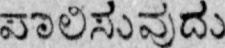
ಪಾಲಿಸುವುದು
